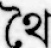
থৈ
